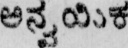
ಅನ್ವಯಿಕ
